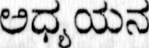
ಅಧ್ಯಯನ
